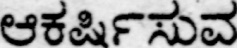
ಆಕರ್ಷಿಸುವ
